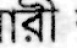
ৱারী
